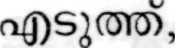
എടുത്ത്,
